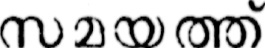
സമയത്ത്
